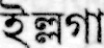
ইল্লগা
